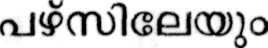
പഴ്സിലേയും
